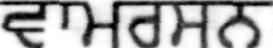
ਵਾਮਰਸਨ
